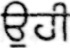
ਉਹੀ
